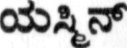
ಯಸ್ಮಿನ್
